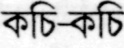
কচি-কচি
